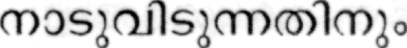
നാടുവിടുന്നതിനും
